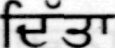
ਦਿੱਤਾ
